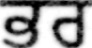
ਭਰ
